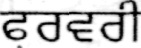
ਫ਼ਰਵਰੀ
